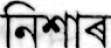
নিশাৰ
